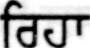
ਰਿਹਾ
